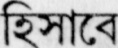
হিসাবে
